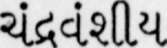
ચંદ્રવંશીય
